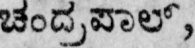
ಚಂದ್ರಪಾಲ್,
